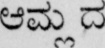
ಆಮ್ಲದ
